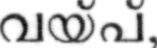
വയ്പ്,
